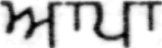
ਆਪਾ
